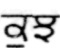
ਕੁਝ
